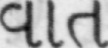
વાત
